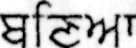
ਬਣਿਆ
